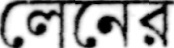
লেনের
